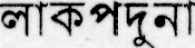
লাকপদুনা
